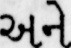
અને
